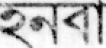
হনবা
